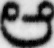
ಆ
